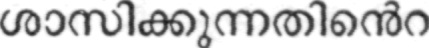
ശാസിക്കുന്നതിന്റെ
